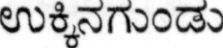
ಉಕ್ಕಿನಗುಂಡು
